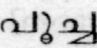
പൂച്ച
